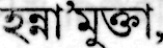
হন্না’মুক্তা,
